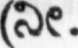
(ನೀ.
